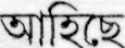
আহিছে
